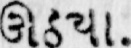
ઊઠ્યા.
